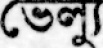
ভেল্যু
